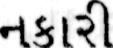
નકારી
